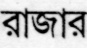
রাজার
